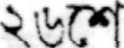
২৬শে
